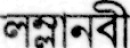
লম্লানবী
